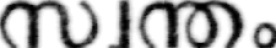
സ്വന്തം
